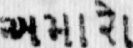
અમારો
